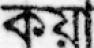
কয়া
